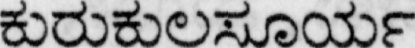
ಕುರುಕುಲಸೂರ್ಯ
